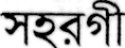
সহরগী
